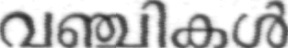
വഞ്ചികള്‍
